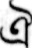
ঐ
